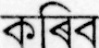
কৰিব
